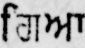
ਗਿਆ
